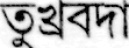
তুখ্রবদা
